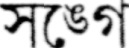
সঙ্গে
